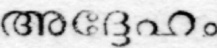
അദ്ദേഹം
